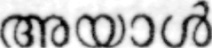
അയാള്‍
